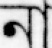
না
